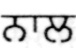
ਨਾਲ
